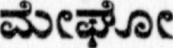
ಮೇಘೋ
